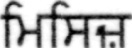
ਮਿਸਿਜ਼
